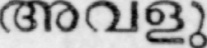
അവളു
